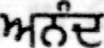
ਅਨੰਦ
